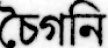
চৈগনি
